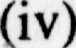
(iv)
